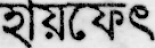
হায়ফেৎ
